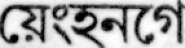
য়েংহনগে
